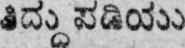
ತಿದ್ದುಪಡಿಯು
